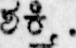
ಶಕ್ತಿ.
